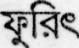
ফুরিৎ
